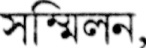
সম্মিলন,
